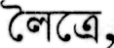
লৈত্রে,
